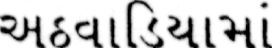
અઠવાડિયામાં
